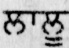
ਲਾਲੂ
